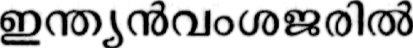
ഇന്ത്യന്‍വംശജരില്‍
